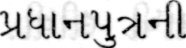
પ્રધાનપુત્રની
